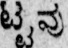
ಟ್ಟವು
